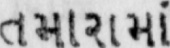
તમારામાં
